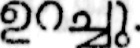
ഉറച്ചു.
